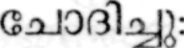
ചോദിച്ചു:
